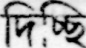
দিচ্ছি
